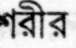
শরীর
